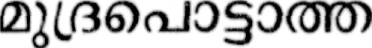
മുദ്രപൊട്ടാത്ത
